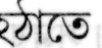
হঠাতে
